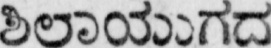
ಶಿಲಾಯುಗದ
